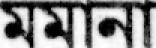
মমানা
